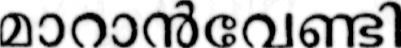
മാറാന്‍വേണ്ടി
